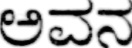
ಅವನ
